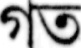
গত
